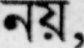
নয়,
